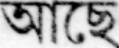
আছে
